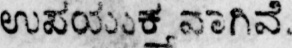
ಉಪಯುಕ್ತವಾಗಿವೆ.
